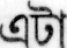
এটা
